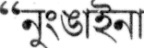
“নুংঙাইনা
